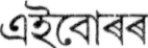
এইবোৰৰ
